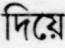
দিয়ে
